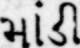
માંડી
